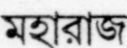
মহারাজ
